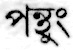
পন্থুং
